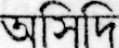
অসিদি
